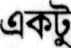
একটু
